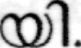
യി.
